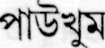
পাউখুম
